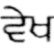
ਵੇਖ
